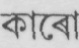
কাৰো
